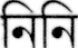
নিনি
